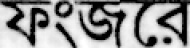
ফংজরে
